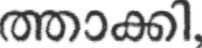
ത്താക്കി,
